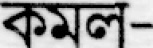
কমল-
